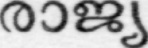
രാജ്യ
